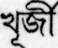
খূর্জী
